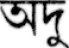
অদু
